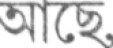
আছে,
